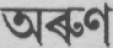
অৰুণ
